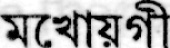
মখোয়গী
